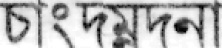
চাংদম্নদনা
